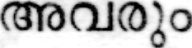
അവരും
